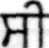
ਸੀ
